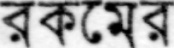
রকমের
